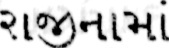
રાજીનામાં
